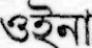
ওইনা
